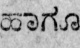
ಹಾಗೂ
